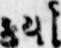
કર્યા
